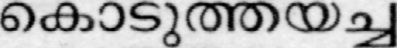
കൊടുത്തയച്ച
